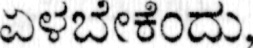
ಏಳಬೇಕೆಂದು,
